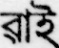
ৱাই
